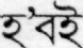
হ'বই
